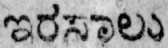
ಇರಸಾಲು
